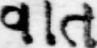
વાત
